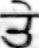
ਤੇ
